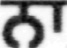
ਨਾ
